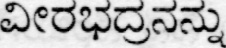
ವೀರಭದ್ರನನ್ನು
